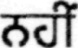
ਨਹੀਂ
